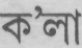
ক'লা
